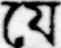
যে
